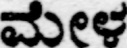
ಮೇಳ
